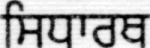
ਸਿਧਾਰਥ
